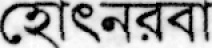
হোৎনরবা
